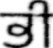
ਭੀ
